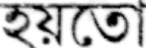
হয়তো
